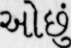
ઓછું
